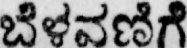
ಬೆಳವಣಿಗೆ
